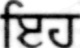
ਇਹ
